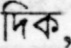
দিক,
